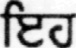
ਇਹ
